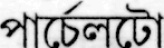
পার্চেলটো
